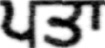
ਪਤਾ
